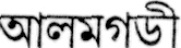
আলমগড়ী
